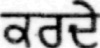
ਕਰਦੇ
